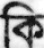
কি
